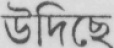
উদিছে
